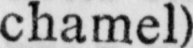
chamel)
